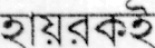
হায়রকই
